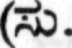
(ಸು.
